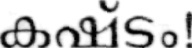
കഷ്ടം!
